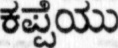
ಕಪ್ಪೆಯು
